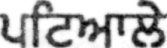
ਪਟਿਆਲੇ
